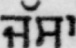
ਜੱਸਾ
